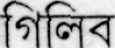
গিলিব
